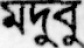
মদুবু
